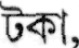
টকা,
